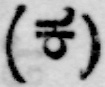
(ಕ)
